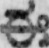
ಈ
